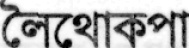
লৈথোকপা
